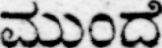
ಮುಂದೆ
